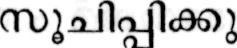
സൂചിപ്പിക്കു
